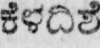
ಕೆಳದಿಶೆ
